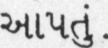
આપતું.
